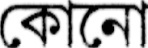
কোনো
